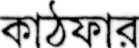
কাঠফার
